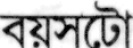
বয়সটো
